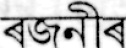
ৰজনীৰ
